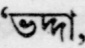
‘ভদ্দা,
